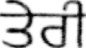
ਤੇਰੀ
